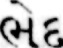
ભેદ
